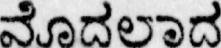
ಮೊದಲಾದ
